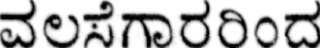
ವಲಸೆಗಾರರಿಂದ
